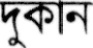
দুকান
